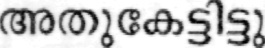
അതുകേട്ടിട്ടു
